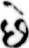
છે
